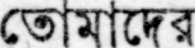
তোমাদের
